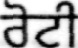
ਰੋਟੀ
